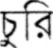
চুরি
